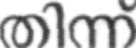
തിന്ന്
